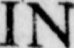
IN
